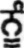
ਨੂੰ
